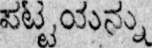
ಪಟ್ಟಿಯನ್ನು
